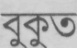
বুকুত
